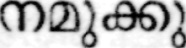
നമുക്കു
